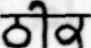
ਠੀਕ
